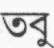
তবু
